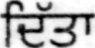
ਦਿੱਤਾ
